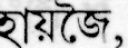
হায়জৈ,
